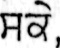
ਸਕੇ,
